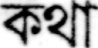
কথা
